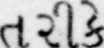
તરીકે
